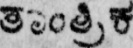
ತಾಂತ್ರಿಕ
